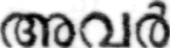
അവര്‍
